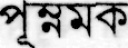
পূম্নমক
